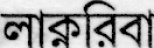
লাক্নরিবা
